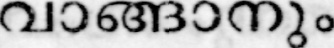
വാങ്ങാനും
